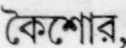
কৈশোর,
